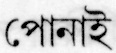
পোনাই
